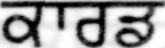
ਕਾਰਡ
